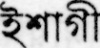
ইশাগী
